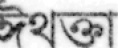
ঈথক্তা
